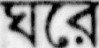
ঘরে
